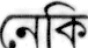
নেকি
